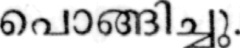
പൊങ്ങിച്ചു.
